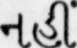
નહીં
